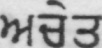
ਅਚੇਤ
